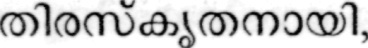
തിരസ്കൃതനായി,
